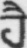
ਹੈ
